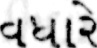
વધારે
